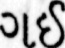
ગઈ
